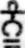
ਨੂੰ
